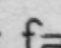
ਵਿ
